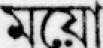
ময়ো
